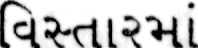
વિસ્તારમાં
